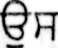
ਉਸ
